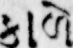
કાળે
